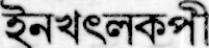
ইনখৎলকপী
